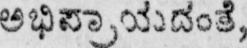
ಅಭಿಪ್ರಾಯದಂತೆ,
